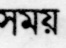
সময়
